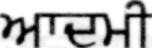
ਆਦਮੀ
